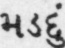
મડદું
